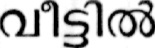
വീട്ടില്‍
